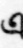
এ
